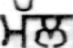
ਮੱਲ
